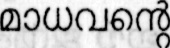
മാധവന്റെ
